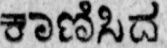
ಕಾಣಿಸಿದ
